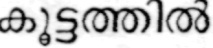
കൂട്ടത്തില്‍
